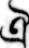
ঐ
